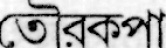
তৌরকপা
